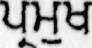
ਪ੍ਰਮੁਖ
